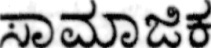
ಸಾಮಾಜಿಕ
